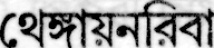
থেঙ্গায়নরিবা
